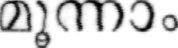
മൂന്നാം
